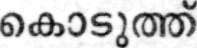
കൊടുത്ത്
